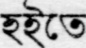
হইতে
